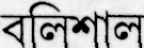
বলিশাল
